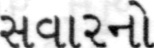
સવારનો
